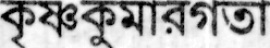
কৃষ্ণকুমারগতা
